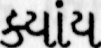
ક્યાંય
